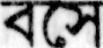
বসে
